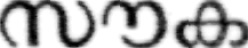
സൌക
